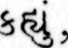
કહ્યું,
